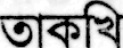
তাকখি
